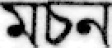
মচন
